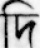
দি
